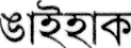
ঙাইহাক
